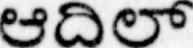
ಆದಿಲ್
